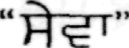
''ਸੇਵਾ''
